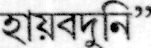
হায়বদুনি”
